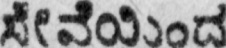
ಸೇವೆಯಿಂದ
